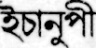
ইচানুপী
